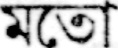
মতো
